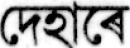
দেহাৰে
